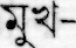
মুখ-
